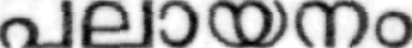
പലായനം
